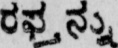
ರಫ್ತನ್ನು
